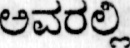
ಅವರಲ್ಲಿ
